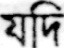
যদি
